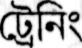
ট্রেনিং
